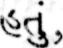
હતું,
